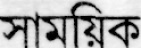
সাময়িক
